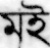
মই
